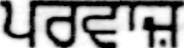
ਪਰਵਾਜ਼
